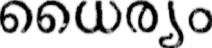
ധൈര്യം
